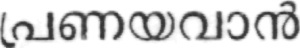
പ്രണയവാന്‍
